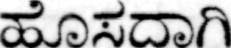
ಹೊಸದಾಗಿ
